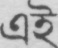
এই
